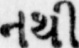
નથી.
